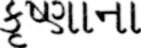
કૃષ્ણાના
